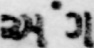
અંગ
